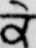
ਕੇ
